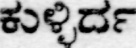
ಕುಳ್ಳಿರ್ದ
